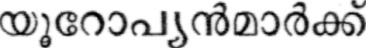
യൂറോപ്യന്‍മാര്‍ക്ക്
